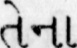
તેના
